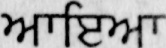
ਆਇਆ
